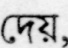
দেয়,
